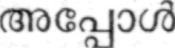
അപ്പോള്‍
